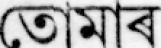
তোমাৰ
